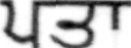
ਪਤਾ
